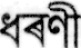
ধৰণী
